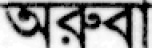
অরুবা
